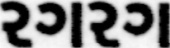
રગરગ
